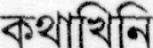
কথাখিনি
